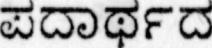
ಪದಾರ್ಥದ
